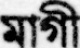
মাগী
